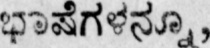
ಭಾಷೆಗಳನ್ನೂ,
